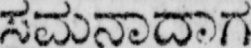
ಸಮನಾದಾಗ
